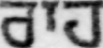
ਰਾਹ
